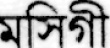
মসিগী
